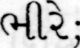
ભીરે;
